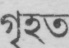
গৃহত
